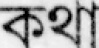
কথা
